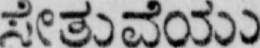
ಸೇತುವೆಯು
